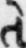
તે
